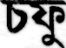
চফু
